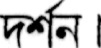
দর্শন।
